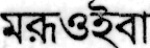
মরূওইবা
